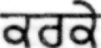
ਕਰਕੇ
